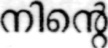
നിന്റെ
